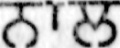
ਨਾਲ
